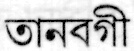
তানবগী
